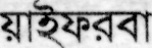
য়াইফরবা
